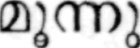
മൂന്നു
